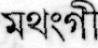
মথংগী
